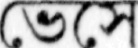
ভেসে
